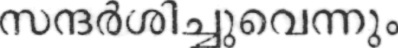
സന്ദര്‍ശിച്ചുവെന്നും
